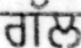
ਗੱਲ
